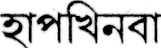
হাপখিনবা
